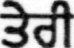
ਤੇਰੀ
